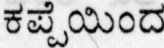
ಕಪ್ಪೆಯಿಂದ
